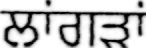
ਲਾਂਗੜਾਂ
